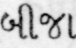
બીજા
